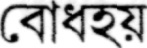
বোধহয়
